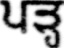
ਪੜ੍ਹ
